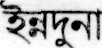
ইন্নদুনা
